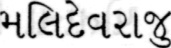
મલિદેવરાજુ
